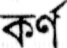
কর্ণ
